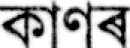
কাণৰ
